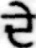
ਦੇ
